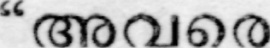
"അവരെ
